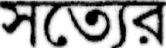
সত্যের
